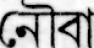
নৌবা
